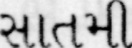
સાતમી
